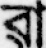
ৱা
